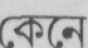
কেনে
